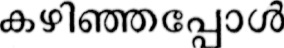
കഴിഞ്ഞപ്പോള്‍
